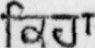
ਕਿਹਾ
